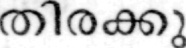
തിരക്കു
